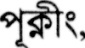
পূক্নীং,
